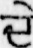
ਦੇ
